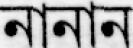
নানান
